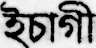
ইচাগী
